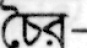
চৈর-
